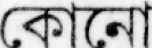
কোনো
